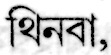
থিনবা,
